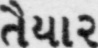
તૈયાર
